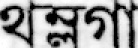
থম্লগা
